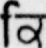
ਕਿ
